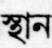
স্থান
